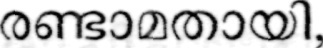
രണ്ടാമതായി,
